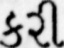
કરી
